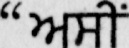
''ਅਸੀਂ
